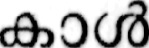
കാള്‍
